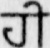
ਹੀ
